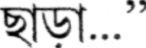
ছাড়া...”
